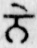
ਨੇ
